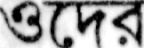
ওদের
